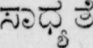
ಸಾಧ್ಯತೆ
